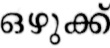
ഒഴുക്ക്
